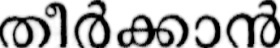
തീര്‍ക്കാന്‍
